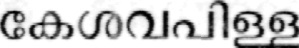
കേശവപിള്ള
